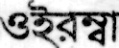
ওইরম্বা
